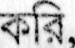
করি,
